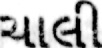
ચાલી
